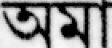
অমা
